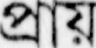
প্রায়
